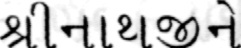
શ્રીનાથજીને
